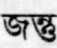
জন্তু
